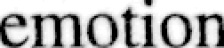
emotion
